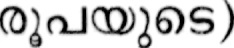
രൂപയുടെ)
